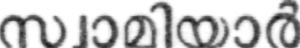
സ്വാമിയാര്‍
